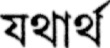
যথার্থ
